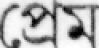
প্রেম
